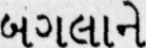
બગલાને
